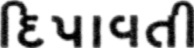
દિપાવતી
